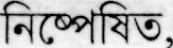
নিষ্পেষিত,
